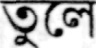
তুলে
